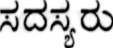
ಸದಸ್ಯರು
